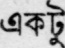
একটু
